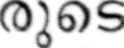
രുടെ
